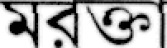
মরক্তা
